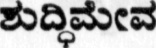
ಶುದ್ಧಿಮೇವ
